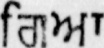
ਗਿਆ
